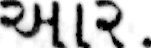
આર.
